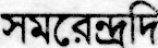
সমরেন্দ্রদি
